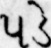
પડે
